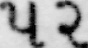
પર
